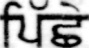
ਪਿੱਛੇ
